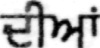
ਦੀਆਂ
